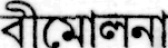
বীমোলনা
